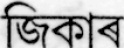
জিকাৰ
